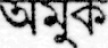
অমুক
